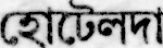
হোটেলদা
